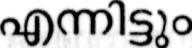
എന്നിട്ടും
